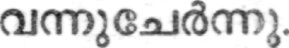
വന്നുചേര്‍ന്നു.
